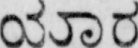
ಯಾರ
